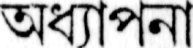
অধ্যাপনা
